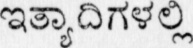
ಇತ್ಯಾದಿಗಳಲ್ಲಿ
